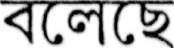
বলেছে
